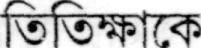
তিতিক্ষাকে
